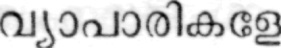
വ്യാപാരികളേ
